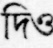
দিও
